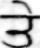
ਤੇ
